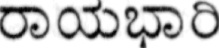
ರಾಯಭಾರಿ
